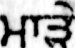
ਮਾੜੇ
